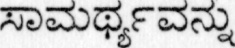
ಸಾಮರ್ಥ್ಯವನ್ನು
